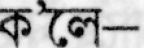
ক'লে-
